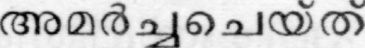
അമര്‍ച്ചചെയ്ത്
